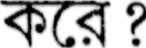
করে?
